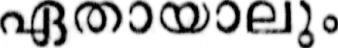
ഏതായാലും
